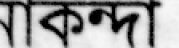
নাকন্দা
